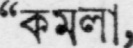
‘‘কমলা,
